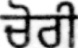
ਚੋਰੀ
